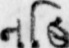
નહિ
